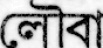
লৌবা
